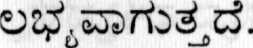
ಲಭ್ಯವಾಗುತ್ತದೆ.
